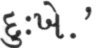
દુઃખે.'
